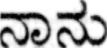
ನಾನು
